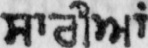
ਸਾਰੀਆਂ
